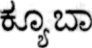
ಕ್ಯೂಬಾ
